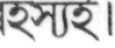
ৰহস্যই।
